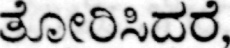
ತೋರಿಸಿದರೆ,
